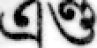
এণ্ড
